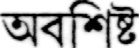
অবশিষ্ট
